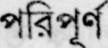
পরিপূর্ণ
